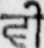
ਵੀ
